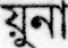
য়ুনা
